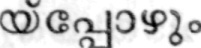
യ്പ്പോഴും
